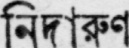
নিদারুণ
